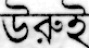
উরুই
